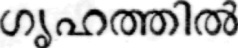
ഗൃഹത്തില്‍
